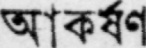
আকর্ষণ
